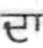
ਦਾ
